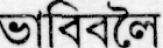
ভাবিবলৈ
